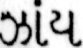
ઝાંય
